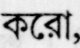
করো,
